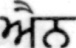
ਐਨ
